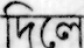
দিলে
